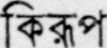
কিরূপ
